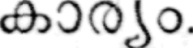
കാര്യം.
